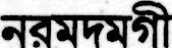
নরমদমগী
